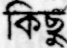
কিছু
